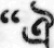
"ঐ
